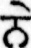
ਨੇ
